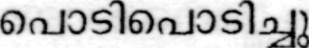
പൊടിപൊടിച്ചു
